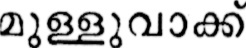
മുള്ളുവാക്ക്
